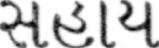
સહાય
